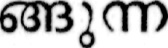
ങ്ങുന്ന
